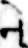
ને
